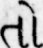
તો
